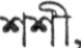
শশী,
